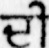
ਦੀ
